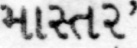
માસ્તર'
